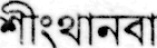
শীংথানবা
